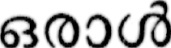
ഒരാള്‍
